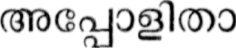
അപ്പോളിതാ
